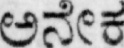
ಅನೇಕ
